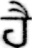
ਹੈ
